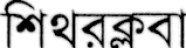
শিথরক্লবা
